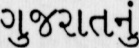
ગુજરાતનું
